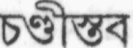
চণ্ডীস্তব
